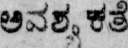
ಅವಶ್ಯಕತೆ
